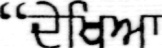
''ਦੇਖਿਆ
